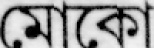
মোকো
